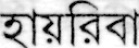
হায়রিবা
